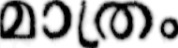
മാത്രം
